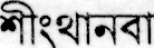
শীংথানবা
